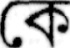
কে
